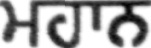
ਮਹਾਨ
